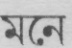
মনে
